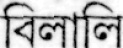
বিলালি
